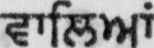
ਵਾਲਿਆਂ
